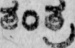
ತಂತ್ರ
